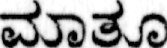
ಮಾತೂ
